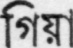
গিয়া
